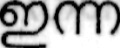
ഇന്ന
